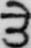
ਤੇ
